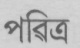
পৱিত্ৰ
